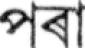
পৰা
